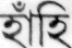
হাঁহি
